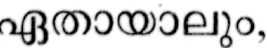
ഏതായാലും,
